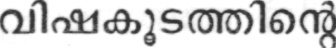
വിഷകൂടത്തിന്റെ
